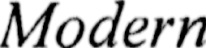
Modern
